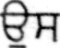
ਉਸ
